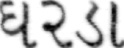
ઘરડા
